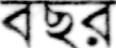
বছর
